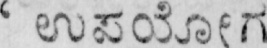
‘ಉಪಯೋಗ
